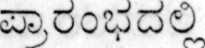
ಪ್ರಾರಂಭದಲ್ಲಿ
